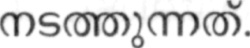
നടത്തുന്നത്.
